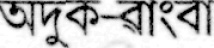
অদুক-ৱাংবা
